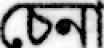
চেনা
